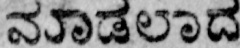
ಮಾಡಲಾದ
